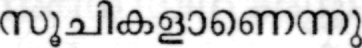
സൂചികളാണെന്നു
